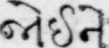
જોઈને
